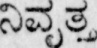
ನಿವೃತ್ತ
